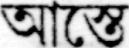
আস্তে
